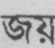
জয়
